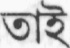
তাই
